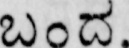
ಬಂದ.
